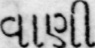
વાણી
